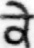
ਕੇ
